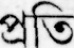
প্রতি
